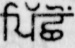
ਪਿੱਛੋਂ
